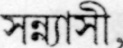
সন্ন্যাসী,
